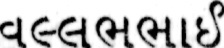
વલ્લભભાઈ
